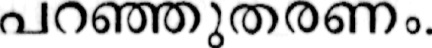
പറഞ്ഞുതരണം.
